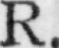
R.
